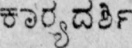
ಕಾರ್‍ಯದರ್ಶಿ
